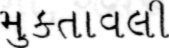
મુક્તાવલી
